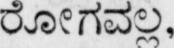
ರೋಗವಲ್ಲ,
